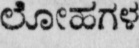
ಲೋಹಗಳ
